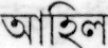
আহিল
